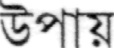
উপায়
